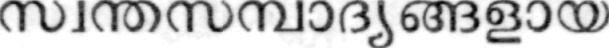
സ്വന്തസമ്പാദ്യങ്ങളായ
